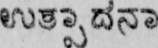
ಉತ್ಪಾದನಾ
